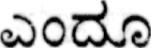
ಎಂದೂ
